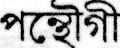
পন্থৌগী
